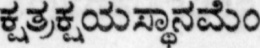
ಕ್ಷತ್ರಕ್ಷಯಸ್ಥಾನಮೆಂ
